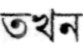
তখন
